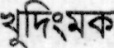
খুদিংমক
